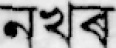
নখৰ
